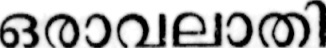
ഒരാവലാതി
